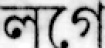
লগে
